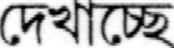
দেখাচ্ছে
